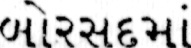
બોરસદમાં
